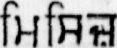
ਮਿਸਿਜ਼
